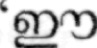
'ഈ
